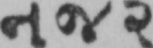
નજર
